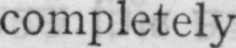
completely
